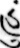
હું
